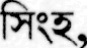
সিংহ,
